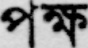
পক্ষ
